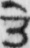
ਤੇ
